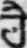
ਹੈ
